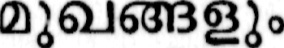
മുഖങ്ങളും
